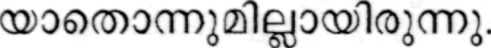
യാതൊന്നുമില്ലായിരുന്നു.
